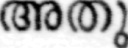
അതു
